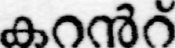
കറന്റ്
